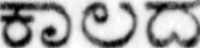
ಕಾಲದ
